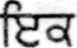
ਇਕ
